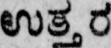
ಉತ್ತರ
